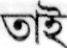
তাই
